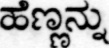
ಹೆಣ್ಣನ್ನು
